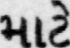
માટે
